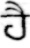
ਹੈ
